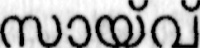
സായ്വ്
